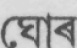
ঘোৰ
